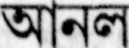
আনল
